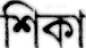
শিকা
